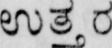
ಉತ್ತರ
